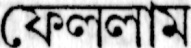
ফেললাম
